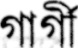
গার্গী
